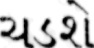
ચડશે
